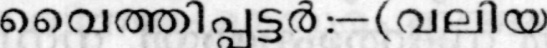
വൈത്തിപ്പട്ടര്‍:-(വലിയ
